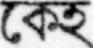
কেহ
